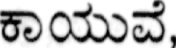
ಕಾಯುವೆ,
